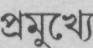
প্ৰমুখ্যে
